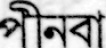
পীনবা
